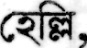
হেল্লি,
